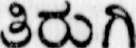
ತಿರುಗಿ
